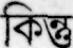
কিন্তু
